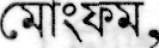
মোংফম,
